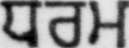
ਧਰਮ
